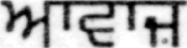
ਆਵਾਜ਼
